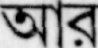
আর
